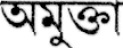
অমুক্তা
